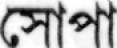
সোপা
